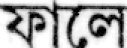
ফালে
